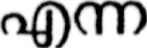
എന്ന
